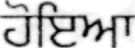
ਹੋਇਆ
